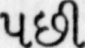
પછી
